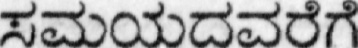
ಸಮಯದವರೆಗೆ
